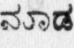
ಮಾಡ
